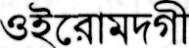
ওইরোমদগী
